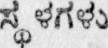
ಸ್ಥಳಗಳು
